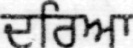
ਦਰਿਆ
